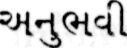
અનુભવી
